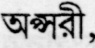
অপ্সরী,
